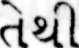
તેથી
